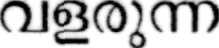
വളരുന്ന
